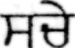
ਸਚੇ
